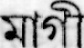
মাগী
